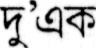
দু'এক
